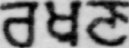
ਰਖਣ
